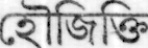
হৌজিক্তি
